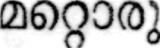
മറ്റൊരു
